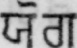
ਯੋਗ
